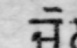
ਜੋ
